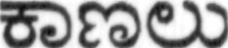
ಕಾಣಲು
